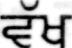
ਵੱਖ
